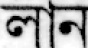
লান
